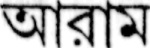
আরাম
